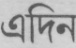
এদিন
